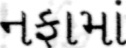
નફામાં
